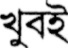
খুবই
